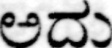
ಅದು
